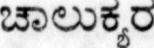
ಚಾಲುಕ್ಯರ
